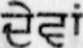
ਦੇਵਾਂ
